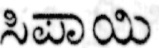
ಸಿಪಾಯಿ
